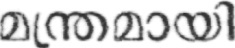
മന്ത്രമായി
